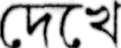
দেখে
